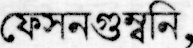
ফেসনগুম্বনি,
